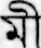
মী
